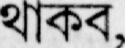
থাকব,
